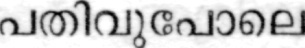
പതിവുപോലെ
